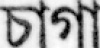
চাগা
